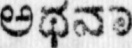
ಅಥವಾ
